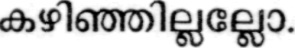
കഴിഞ്ഞില്ലല്ലോ.
